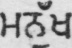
ਮਨੁੱਖ
